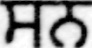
ਸਨ
